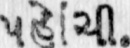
પહોંચી.
